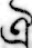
ঐ
